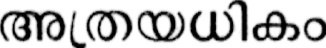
അത്രയധികം
